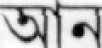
আন
